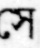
সে
